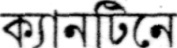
ক্যানটিনে
